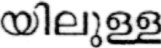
യിലുള്ള
